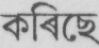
কৰিছে
